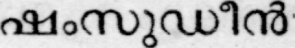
ഷംസുഡീന്‍
